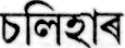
চলিহাৰ
